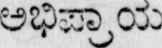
ಅಭಿಪ್ರಾಯ
